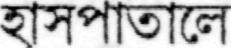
হাসপাতালে
